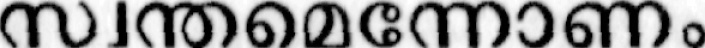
സ്വന്തമെന്നോണം
